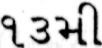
૧૩મી
